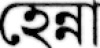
হেন্না
